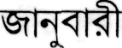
জানুবারী
